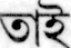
তাই
